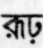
রূঢ়
